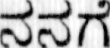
ನನಗೆ
